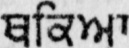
ਥਕਿਆ
